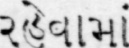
રહેવામાં
